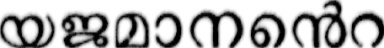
യജമാനന്റെ
